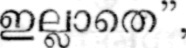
ഇല്ലാതെ",
